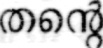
തന്റെ
